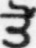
ਤੋਂ
